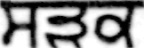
ਸੜਕ
